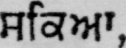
ਸਕਿਆ,
